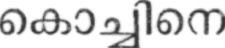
കൊച്ചിനെ
